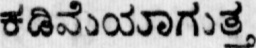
ಕಡಿಮೆಯಾಗುತ್ತ
